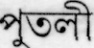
পুতলী
